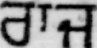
ਰਾਜ
